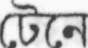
টেনে
